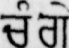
ਚੰਗੇ
